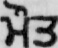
ਮੌਤ
